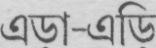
এড়া-এড়ি
